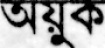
অয়ুক
